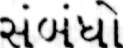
સંબંધો
